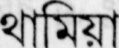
থামিয়া
